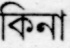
কিনা
